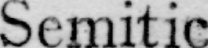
Semitie
